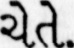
ચેતે.
